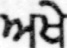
ਅਖੇ
